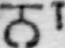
ਨਾ
